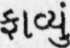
ફાવ્યું
